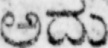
ಅದು
